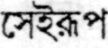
সেইরূপ
